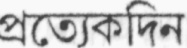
প্রত্যেকদিন
